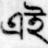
এই
